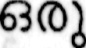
ഒരു
